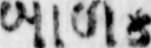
બાળક
